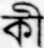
কী
